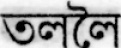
তললৈ
